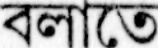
বলাতে
